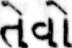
તેવો
